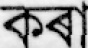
কৰা
